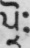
ਪ੍ਰੋ:
